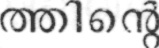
ത്തിന്റെ
